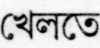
খেলতে
